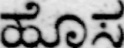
ಹೊಸ
